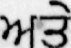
ਅਤੇ
